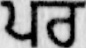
ਪਰ
